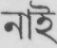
নাই
